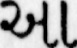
આ
